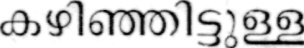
കഴിഞ്ഞിട്ടുള്ള
